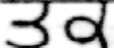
ਤਕ
